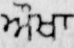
ਔਖਾ
